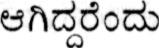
ಆಗಿದ್ದರೆಂದು
